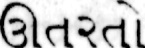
ઊતરતો
